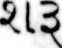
શરૂ
